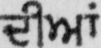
ਦੀਆਂ
